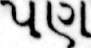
પણ
